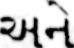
અને
